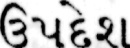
ઉપદેશ
